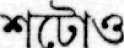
শটোও
